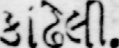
કાઢેલી.
